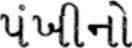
પંખીનો
